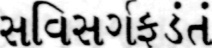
સવિસર્ગફડંતં
